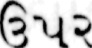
ઉપર
